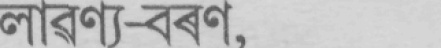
লাৱণ্য-বৰণ,
